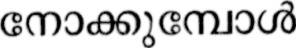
നോക്കുമ്പോള്‍
